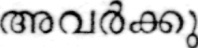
അവര്‍ക്കു
